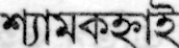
শ্যামকহ্ণাই
